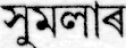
সুমলাৰ
